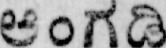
ಅಂಗಡಿ
